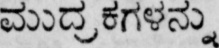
ಮುದ್ರಕಗಳನ್ನು
